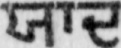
ਯਾਦ
